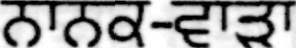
ਨਾਨਕ-ਵਾੜਾ
